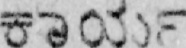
ಕಾರ್ಯ
